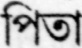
পিতা
